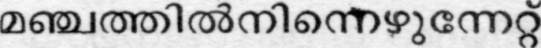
മഞ്ചത്തില്‍നിന്നെഴുന്നേറ്റ്
